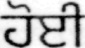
ਹੋਈ
